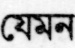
যেমন
